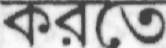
করতে
